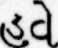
હવે
